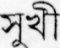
সুখী
